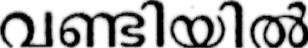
വണ്ടിയില്‍
